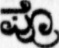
ಪ್ರೊ
